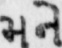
મને
